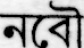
নবৌ
